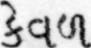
કેવળ
